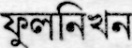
ফুলনিখন
